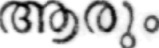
ആരും
